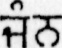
ਜੰਨ
